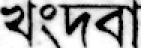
খংদবা
